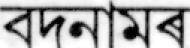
বদনামৰ
